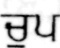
ਚੁਪ
